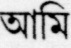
আমি
